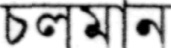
চলমান
